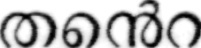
തന്റെ
